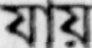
যায়
